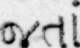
જતાં
